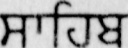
ਸਾਹਿਬ
